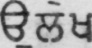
ਉਲੇਖ
